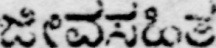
ಜೀವಸಹಿತ
